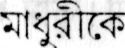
মাধুরীকে
